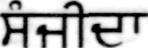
ਸੰਜੀਦਾ
